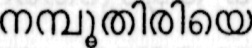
നമ്പൂതിരിയെ
